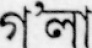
গ'লা
